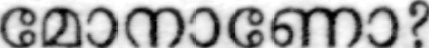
മോനാണോ?
